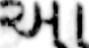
આ
